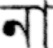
না
